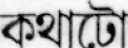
কথাটো
